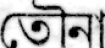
তৌনা
